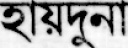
হায়দুনা
